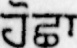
ਹੋਛਾ
